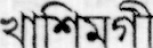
খাশিমগী
